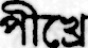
পীখ্রে
